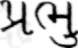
પ્રભુ
